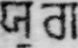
ਯੁਗ
